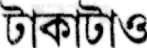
টাকাটাও
